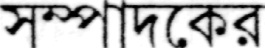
সম্পাদকের
